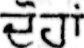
ਦੋਹਾਂ
